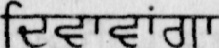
ਦਿਵਾਵਾਂਗਾ
